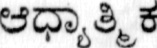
ಆಧ್ಯಾತ್ಮಿಕ
